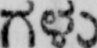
ಗಳು
